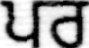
ਪਰ
